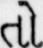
તો
